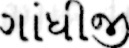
ગાંધીજી
